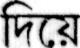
দিয়ে
